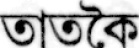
তাতকৈ
